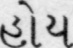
હોય
